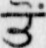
ਤੋਂ
